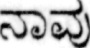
ನಾವು
